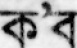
ক'ব
